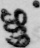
છુ
